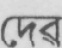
দেৱ
